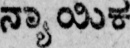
ನ್ಯಾಯಿಕ
